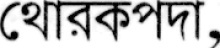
থোরকপদা,
